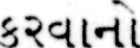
કનવાનો
